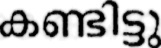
കണ്ടിട്ടു
